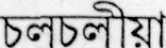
চলচলীয়া
